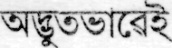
অদ্ভুতভাৱেই
